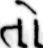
તો
